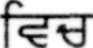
ਵਿਚ
